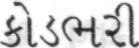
કોડભરી
